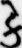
કે
